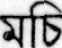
মচি
